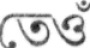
তেওঁ
